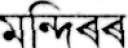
মন্দিৰৰ
